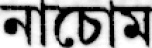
নাচোম
